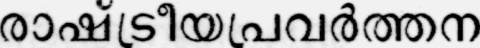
രാഷ്ട്രീയപ്രവര്‍ത്തന
